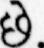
છે.
